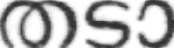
തടാ
